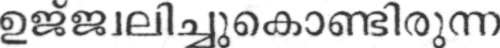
ഉജ്ജ്വലിച്ചുകൊണ്ടിരുന്ന
